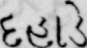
દહાડે
